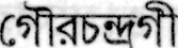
গৌরচন্দ্রগী
